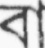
বা
